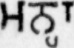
ਮਨ੍ਹਾ
